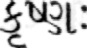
કૃષ્ણઃ
